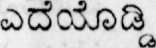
ಎದೆಯೊಡ್ಡಿ
